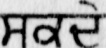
ਸਕਦੇ
